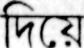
দিয়ে
